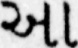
આ
